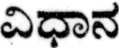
ವಿಧಾನ
